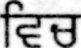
ਵਿਚ
